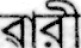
ৱারী
